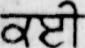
ਕਈ
